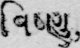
વિષ્ણુ,
